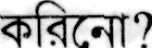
করিনো?
